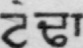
ਟੇਢਾ
